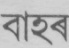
বাহৰ
